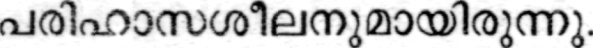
പരിഹാസശീലനുമായിരുന്നു.
